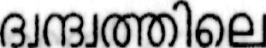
ദ്വന്ദ്വത്തിലെ
